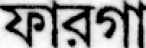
ফারগা
